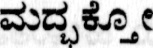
ಮದ್ಭಕ್ತೋ
